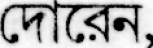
দোরেন,
